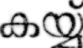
കയ്യ്
